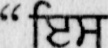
''ਇਸ
